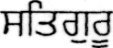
ਸਤਿਗੁਰੂ
